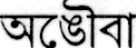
অঙৌবা
